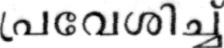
പ്രവേശിച്ച്
